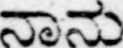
ನಾನು
